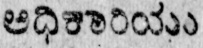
ಅಧಿಕಾರಿಯು
